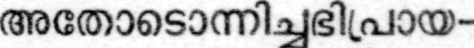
അതോടൊന്നിച്ചഭിപ്രായ-
